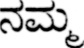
ನಮ್ಮ
